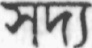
সদ্য
